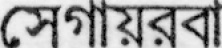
সেগায়রবা
